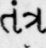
તંત્ર
